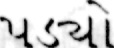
પડ્યો
